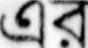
এর
